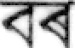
বৰ
